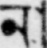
না
